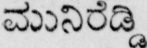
ಮುನಿರೆಡ್ಡಿ
